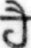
ਹੈ
